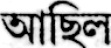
আছিল
